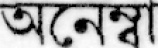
অনেম্বা
